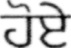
ਹੋਏ
